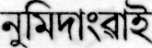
নুমিদাংৱাই
